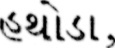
હથોડા,
